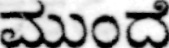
ಮುಂದೆ
